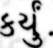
કર્યું.
